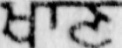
ਖਾਣ
